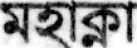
মহাক্না
